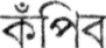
কঁপিব
